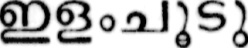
ഇളംചൂടു
